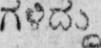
ಗಳಿದ್ದು
